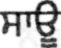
ਸਾਊ
